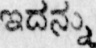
ಇದನ್ನು
